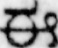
ಈ
